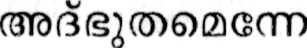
അദ്ഭുതമെന്നേ
